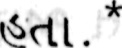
હતા.★
